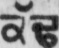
ਕੱਢ
